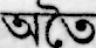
অতৈ
